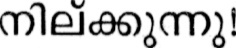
നില്ക്കുന്നു!
